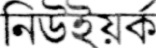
নিউইয়র্ক
